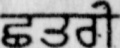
ਛਤਰੀ
